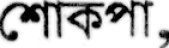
শোকপা,
